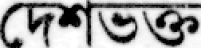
দেশভক্ত
